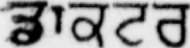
ਡਾਕਟਰ
